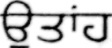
ਉਤਾਂਹ
